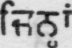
ਜਿਨ੍ਹਾਂ
